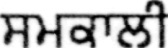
ਸਮਕਾਲੀ
